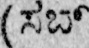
(ಸಬ್
